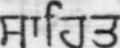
ਸਾਹਿਤ
